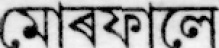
মোৰফালে
